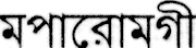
মপারোমগী
